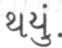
થયું.
